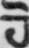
ਹੋ
